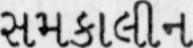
સમકાલીન
